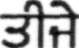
ਤੀਜੇ
